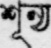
শূন্য
